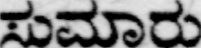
ಸುಮಾರು
